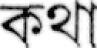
কথা
